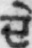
ਦੇ
